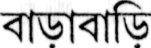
বাড়াবাড়ি
